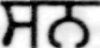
ਸਨ
